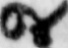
જ
